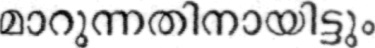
മാറുന്നതിനായിട്ടും
